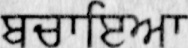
ਬਚਾਇਆ
